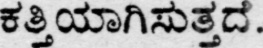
ಕತ್ತಿಯಾಗಿಸುತ್ತದೆ.
